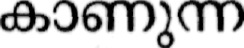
കാണുന്ന
